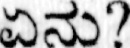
ಏನು?
